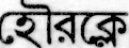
হৌরক্লে
